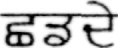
ਛਡਦੇ
